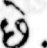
છે.
